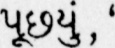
પૂછયું,'
